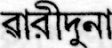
ৱারীদুনা
